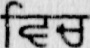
ਵਿਚ
